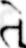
તે
